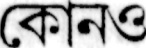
কোনও
